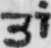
ਤਾਂ
